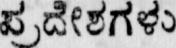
ಪ್ರದೇಶಗಳು
